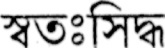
স্বতঃসিদ্ধ
